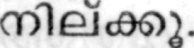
നില്ക്കൂ.
